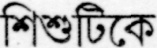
শিশুটিকে
